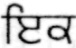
ਇਕ
